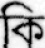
কি
